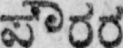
ಪೌರರ
